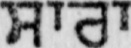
ਸਾਰਾ
